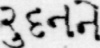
રુદનને
